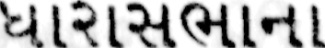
ધારાસભાના
